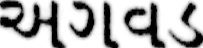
અગવડ
